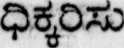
ಧಿಕ್ಕರಿಸು
